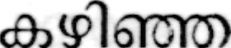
കഴിഞ്ഞ
